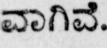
ವಾಗಿವೆ.
